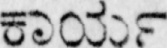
ಕಾರ್ಯ
